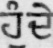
ਹੁੰਦੇ
